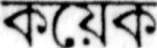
কয়েক
